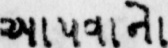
આપવાનો
